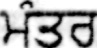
ਮੰਤਰ
